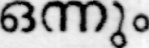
ഒന്നും
